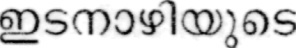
ഇടനാഴിയുടെ
